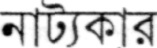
নাট্যকার
